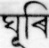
ঘূৰি
